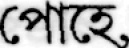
পোহে,
